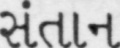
સંતાન
